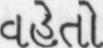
વહેતો
